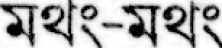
মথং-মথং
